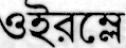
ওইরম্লে
